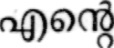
എന്റെ
